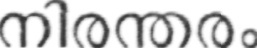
നിരന്തരം
